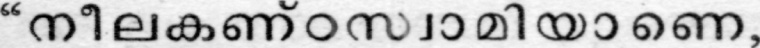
"നീലകണ്ഠസ്വാമിയാണെ,
